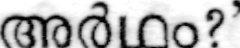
അര്‍ഥം?’
